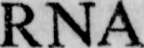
RNA
